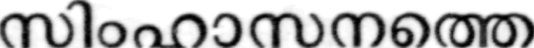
സിംഹാസനത്തെ
